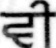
ਵੀ
